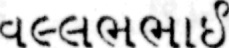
વલ્લભભાઈ
